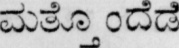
ಮತ್ತೊಂದೆಡೆ
